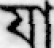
যা
